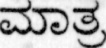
ಮಾತ್ರ
